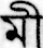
মী
